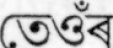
তেওঁৰ
